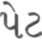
પેટ
